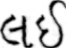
લઈ
